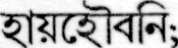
হায়হৌবনি;
